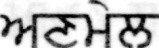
ਅਣਮੇਲ
